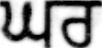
ਘਰ
